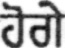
ਹੋਗੇ
